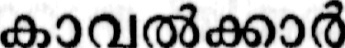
കാവല്‍ക്കാര്‍
